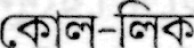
কোল-লিক
